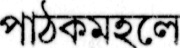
পাঠকমহলে
